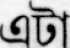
এটা
